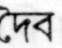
দৈব
